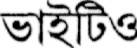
ভাইটিও
